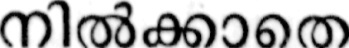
നില്‍ക്കാതെ
